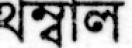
থম্বাল
